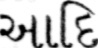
આદિ
